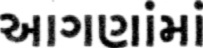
આગણાંમાં
